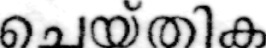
ചെയ്തിക
